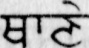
ਥਾਣੇ
